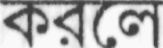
করলে
